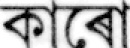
কাৰো
